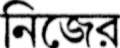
নিজের
